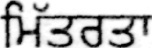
ਮਿੱਤਰਤਾ
